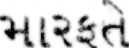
મારફતે
